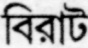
বিরাট
